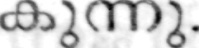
കുന്നു.
